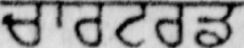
ਚਾਰਟਰਡ
